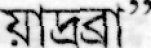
য়াদ্রব্রা”
